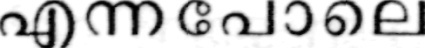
എന്നപോലെ
